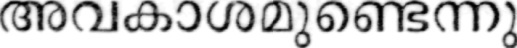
അവകാശമുണ്ടെന്നു
